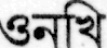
ওনখি
